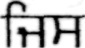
ਜਿਸ
